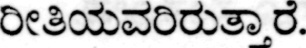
ರೀತಿಯವರಿರುತ್ತಾರೆ.
